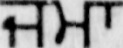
ਜਮਾ
